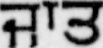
ਜਾਤ
